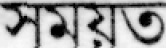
সময়ত
